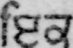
ਇਕ
